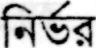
নির্ভর
